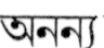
অনন্য
